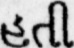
હતી
